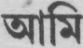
আমি
